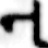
ન
